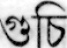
গুচি
